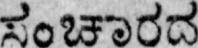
ಸಂಚಾರದ
